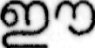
ഈ
